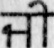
ਜੀ
